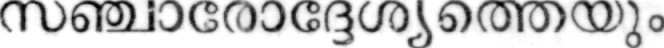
സഞ്ചാരോദ്ദേശ്യത്തെയും
